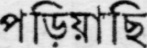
পড়িয়াছি
